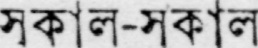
সকাল-সকাল
